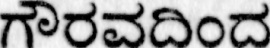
ಗೌರವದಿಂದ
